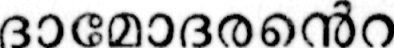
ദാമോദരന്റെ
